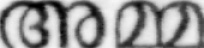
അമ്മ
